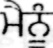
ਮੈਨੂੰ
